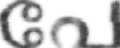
പേ
